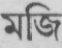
মজি
